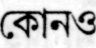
কোনও
